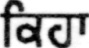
ਕਿਹਾ
